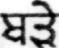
ਬੜੇ
